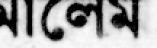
মালেম
